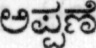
ಅಪ್ಪಣೆ
